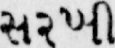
સરખી
